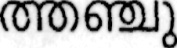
ത്തഞ്ചു
